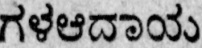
ಗಳಆದಾಯ
